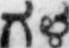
ಗಳ
